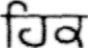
ਹਿਕ
